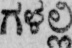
ಗಳಲ್ಲಿ
